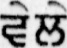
ਵੇਲੇ
